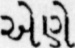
એણે
